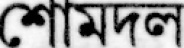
শোমদল
